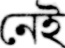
নেই
